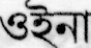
ওইনা
